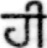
ਹੀ
